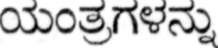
ಯಂತ್ರಗಳನ್ನು
